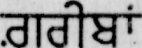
ਗ਼ਰੀਬਾਂ
